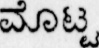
ಮೊಟ್ಟ
